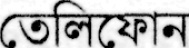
তেলিফোন
